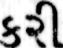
કરી
